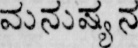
ಮನುಷ್ಯನ
